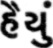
હૈયું
